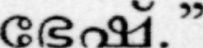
ഭേഷ്."
